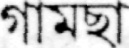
গামছা
